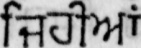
ਜਿਹੀਆਂ
